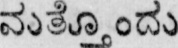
ಮತ್ತೊಂದು
